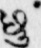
છું
